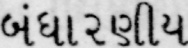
બંધારણીય
